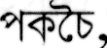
পকচৈ,
